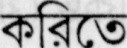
করিতে
